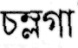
চম্লগা
